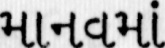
માનવમાં
